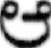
ಆ
